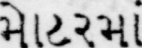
મોટરમાં
